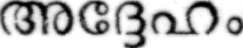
അദ്ദേഹം
